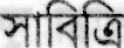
সাবিত্রি
